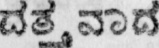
ದತ್ತವಾದ
